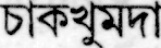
চাকখুমদা
